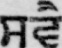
ਸਵੈ
